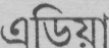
এড়িয়া
